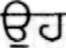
ਉਹ
